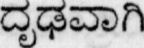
ದೃಢವಾಗಿ
